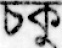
চকু
